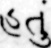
હતું
